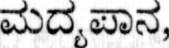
ಮದ್ಯಪಾನ,
